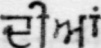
ਦੀਆਂ
